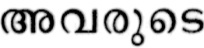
അവരുടെ
